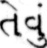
તેવું
